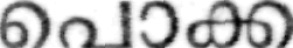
പൊക്ക
